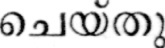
ചെയ്തു
